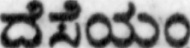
ದೆಸೆಯಂ
